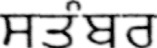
ਸਤੰਬਰ
